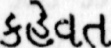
કહેવત
